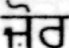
ਜ਼ੋਰ
